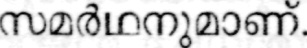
സമര്‍ഥനുമാണ്.
